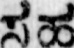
ಸಹ
